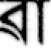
ৱা
